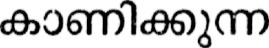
കാണിക്കുന്ന
